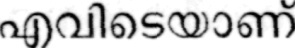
എവിടെയാണ്
